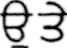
ਉਤੇ
